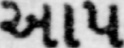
આપ
